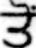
ਤੋਂ
